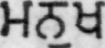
ਮਨੁਖ
